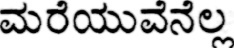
ಮರೆಯುವೆನೆಲ್ಲ
